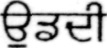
ਉਡਦੀ
